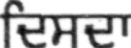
ਦਿਸਦਾ
